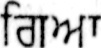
ਗਿਆ
